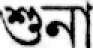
শুনা
